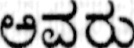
ಅವರು
